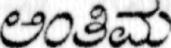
ಅಂತಿಮ
